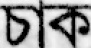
চাক
